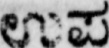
ಉಪ
